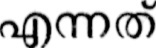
എന്നത്
